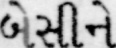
બેસીને
